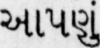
આપણું
